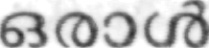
ഒരാള്‍
